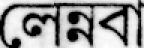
লেন্নবা
